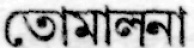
তোমালনা
